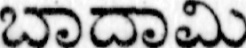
ಬಾದಾಮಿ
